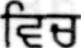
ਵਿਚ
